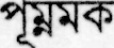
পূম্নমক
